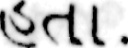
હતા.
